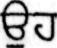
ਉਹ
